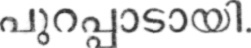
പുറപ്പാടായി.
